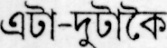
এটা-দুটাকৈ
